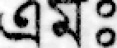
এমঃ
